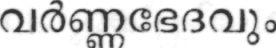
വര്‍ണ്ണഭേദവും
